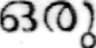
ഒരു
